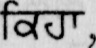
ਕਿਹਾ,
